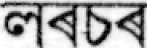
লৰচৰ
